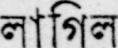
লাগিল
